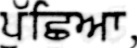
ਪੁੱਛਿਆ,
